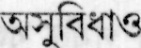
অসুবিধাও
